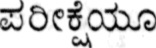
ಪರೀಕ್ಷೆಯೂ
